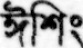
ঈশিং
